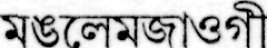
মঙলেমজাওগী
